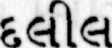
દલીલ
